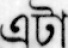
এটা
